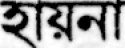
হায়না
